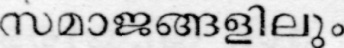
സമാജങ്ങളിലും
